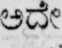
ಅದೇ
